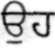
ਉਹ
